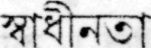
স্বাধীনতা
